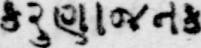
કરુણાજનક
